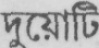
দুয়োটি
